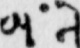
બંને
